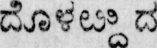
ದೊಳೞ್ದದ
